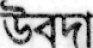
উবদা
